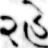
રહે
